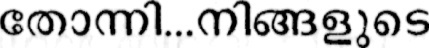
തോന്നി...നിങ്ങളുടെ
